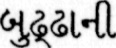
બુઢ્ઢાની
